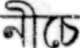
নীচে
